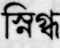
স্নিগ্ধ
